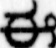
ಈ
